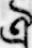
ঐ
